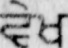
ਵੇਖ
